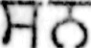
ਸਨ
